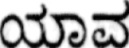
ಯಾವ
